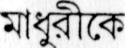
মাধুরীকে
